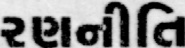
રણનીતિ
